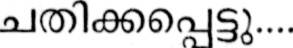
ചതിക്കപ്പെട്ടു....
